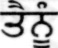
ਤੈਨੂੰ
